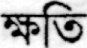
ক্ষতি
